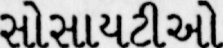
સોસાયટીઓ
